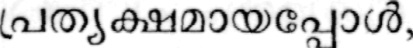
പ്രത്യക്ഷമായപ്പോള്‍,
